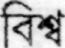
বিশ্ব
